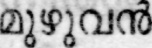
മുഴുവന്‍
